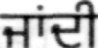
ਜਾਂਦੀ
